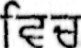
ਵਿਚ
